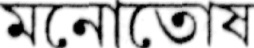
মনোতোষ
